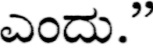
ಎಂದು."
